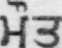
ਮੌਤ
